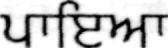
ਪਾਇਆ
